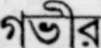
গভীর
